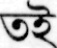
তই
